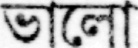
ভালো
